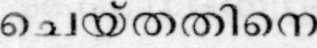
ചെയ്തതിനെ
